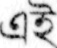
এই
